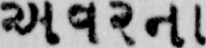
અવરના
